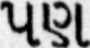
પણ
